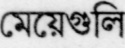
মেয়েগুলি
